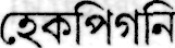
হেকপিগনি
